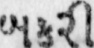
બકરી
